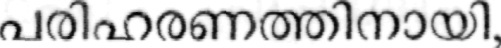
പരിഹരണത്തിനായി,
